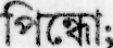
পিন্ধো;
